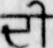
ਦੀ
